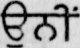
ਉਨੀਂ
